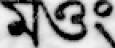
মওং
